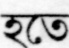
হতে
